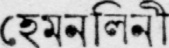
হেমনলিনী
